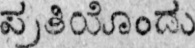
ಪ್ರತಿಯೊಂದು
